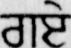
ਗਏ
